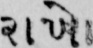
રાખો
